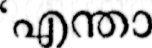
'എന്താ
